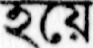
হয়ে
